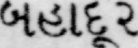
બહાદૂર
